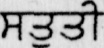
ਸਤੁਤੀ
